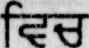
ਵਿਚ
